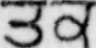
ਤਕ
